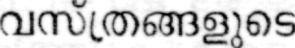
വസ്ത്രങ്ങളുടെ
